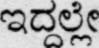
ಇದ್ದಲ್ಲೇ
